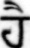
ਹੈ
